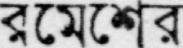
রমেশের
